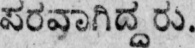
ಪರವಾಗಿದ್ದರು.
